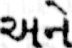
અને
